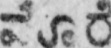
ಮೊರೆ
